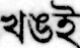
খঙই
